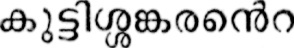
കുട്ടിശ്ശങ്കരന്റെ
